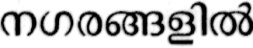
നഗരങ്ങളില്‍
